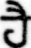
ਹੈ
